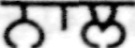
ਨਾਲ
